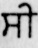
ਸੀ
